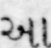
આ
